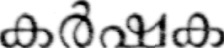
കര്‍ഷക
